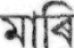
মাৰি
